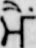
ਮੈਂ
